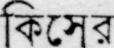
কিসের
